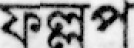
ফল্লপ
